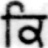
ਕਿ
